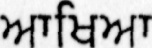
ਆਖਿਆ
